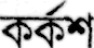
কর্কশ
